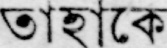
তাহাকে
